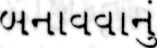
બનાવવાનું
